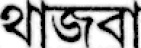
থাজবা
